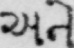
અને
